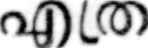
എത്ര
